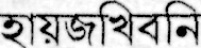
হায়জখিবনি
